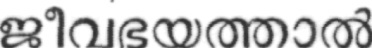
ജീവഭയത്താല്‍
